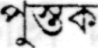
পুস্তক
